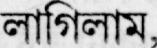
লাগিলাম,
